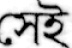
সেই
